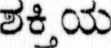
ಶಕ್ತಿಯ
